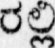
ರಲ್ಲಿ
